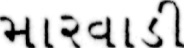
મારવાડી
